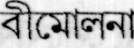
বীমোলনা
